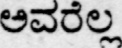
ಅವರೆಲ್ಲ
